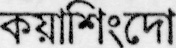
কয়াশিংদো
